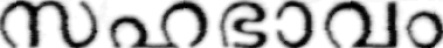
സഹഭാവം
